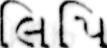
લિપિ
